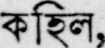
কহিল,
